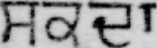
ਸਕਦਾ
